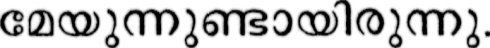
മേയുന്നുണ്ടായിരുന്നു.
